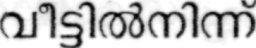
വീട്ടില്‍നിന്ന്
